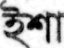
ইশা
